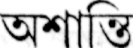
অশান্তি
